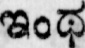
ಇಂಥ
